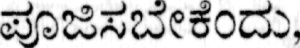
ಪೂಜಿಸಬೇಕೆಂದು,
